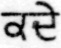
ਕਦੇ
